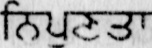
ਨਿਪੁਣਤਾ
